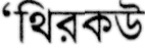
‘থিরকউ
